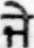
ਜੇ
